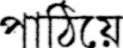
পাঠিয়ে
